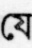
যে
